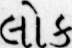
લોક
